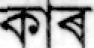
কাৰ
